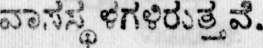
ವಾಸಸ್ಥಳಗಳಿರುತ್ತವೆ.
